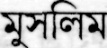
মুসলিম
